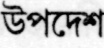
উপদেশ
